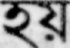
হয়
